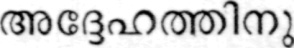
അദ്ദേഹത്തിനു
